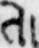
તો
